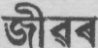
জীৱৰ
